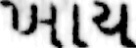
ખાય
